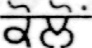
ਕੋਲੋਂ
